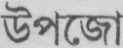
উপজো
